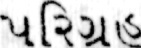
પરિગ્રહ
